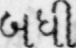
બધી
